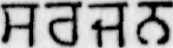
ਸਰਜਨ
